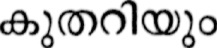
കുതറിയും
